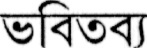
ভবিতব্য
